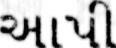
આપી
